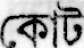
কোট
